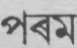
পৰম
